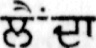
ਲੈਂਦਾ
